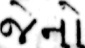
જેનો
